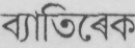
ব্যাতিৰেক
